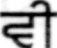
ਵੀ
